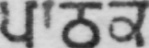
ਪਾਠਕ
